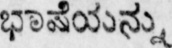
ಭಾಷೆಯನ್ನು
